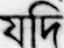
যদি
